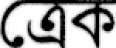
ত্রেক
